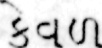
કેવળ
